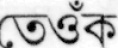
তেওঁক
